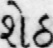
શેઠ
